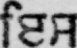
ਇਸ
